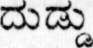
ದುಡ್ಡು
